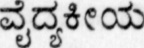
ವೈದ್ಯಕೀಯ
